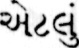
એટલું
